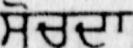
ਸੋਚਦਾ
